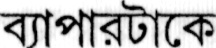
ব্যাপারটাকে
